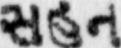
સહન
